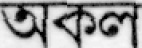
অকল
